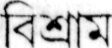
বিশ্রাম
